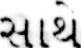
સાથે
